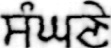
ਸੰਘਣੇ
